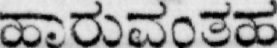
ಹಾರುವಂತಹ
